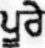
ਪੂਰੇ
